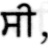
ਸੀ,
